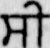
ਸੀ
